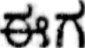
ಈಗ
